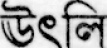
ঊৎলি
